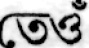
তেওঁ
